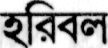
হরিবল
